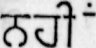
ਨਹੀਂ
